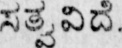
ಸತ್ವವಿದೆ.
